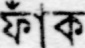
ফাঁক
